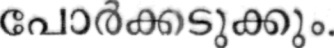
പോര്‍ക്കടുക്കും.
